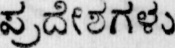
ಪ್ರದೇಶಗಳು
